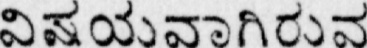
ವಿಷಯವಾಗಿರುವ
